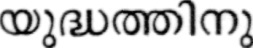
യുദ്ധത്തിനു
